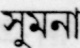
সুমনা
